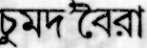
চুমদ’বৈরা
